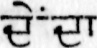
ਦੇਂਦਾ
